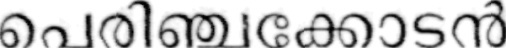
പെരിഞ്ചക്കോടന്‍
